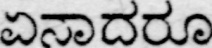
ಏನಾದರೂ
